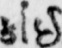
કાંઈ
